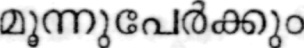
മൂന്നുപേര്‍ക്കും
